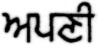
ਅਪਣੀ
